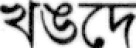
খঙদে
